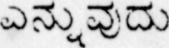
ಎನ್ನುವುದು
